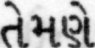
તેમણે
